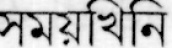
সময়খিনি
